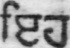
ਇਹ
